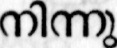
നിന്നു
